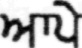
ਆਪੇ
